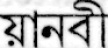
য়ানবী
